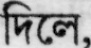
দিলে,
